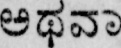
ಅಥವಾ
